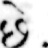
છે.
